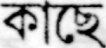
কাছে
